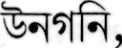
উনগনি,
